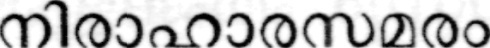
നിരാഹാരസമരം
